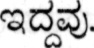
ಇದ್ದವು.
